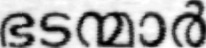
ഭടന്മാര്‍
